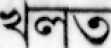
খলত
